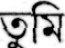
তুমি
